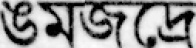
ঙমজদ্রে
